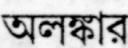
অলঙ্কার
